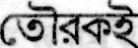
তৌরকই
